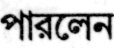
পারলেন
